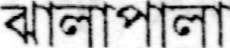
ঝালাপালা
